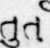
તુર્ત
